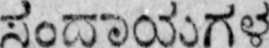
ಸಂದಾಯಗಳ
